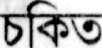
চকিত
